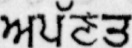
ਅਪੱਣਤ
